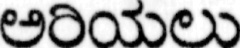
ಅರಿಯಲು
